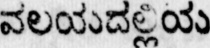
ವಲಯದಲ್ಲಿಯ
